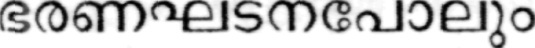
ഭരണഘടനപോലും
